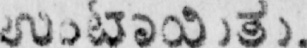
ಉಂಟಾಯಿತು.
